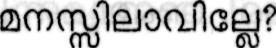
മനസ്സിലാവില്ലേ?
